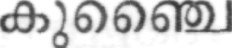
കുഞ്ചൈ
